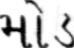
મોડ
